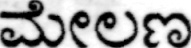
ಮೇಲಣ
